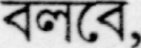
বলবে,
